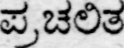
ಪ್ರಚಲಿತ
